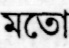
মতো
